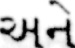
અને
